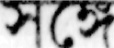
সঙ্গে
